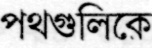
পথগুলিকে
